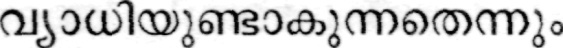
വ്യാധിയുണ്ടാകുന്നതെന്നും
